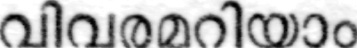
വിവരമറിയാം
